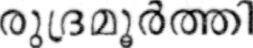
രുദ്രമൂര്‍ത്തി
